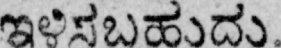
ಇಳಿಸಬಹುದು.
